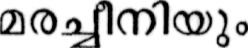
മരച്ചീനിയും
